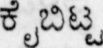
ಕೈಬಿಟ್ಟ
